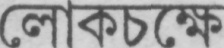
লোকচক্ষে
